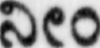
ನೀಂ
